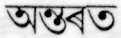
অন্তৰত
